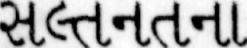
સલ્તનતના
